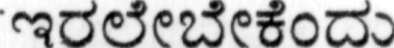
ಇರಲೇಬೇಕೆಂದು
